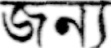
জন্য
